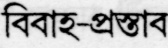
বিবাহ-প্রস্তাব
